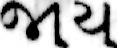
જાય
